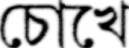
চোখে
